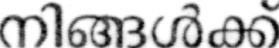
നിങ്ങള്‍ക്ക്
